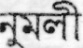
নুমলী
